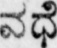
ವಧೆ
